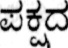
ಪಕ್ಷದ
